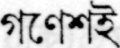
গণেশই
